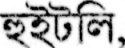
হুইটলি,
